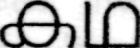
കഥ
